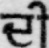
ਦੀ
